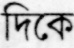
দিকে
